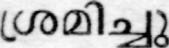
ശ്രമിച്ചു
